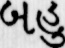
બહુ
